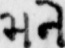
મને
